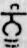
ਨੂੰ
